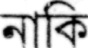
নাকি
